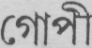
গোপী
